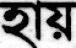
হায়
